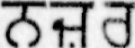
ਨਜ਼ਰ
